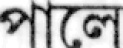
পালে
